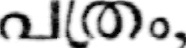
പത്രം,
